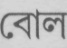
বোল
